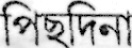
পিছদিনা
